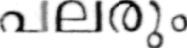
പലരും
